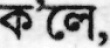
ক'লে,
